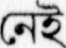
নেই
